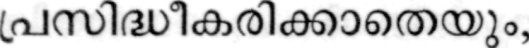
പ്രസിദ്ധീകരിക്കാതെയും,
